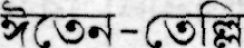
ঈতেন-তেল্লি
